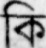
কি
